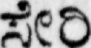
ಸೇರಿ
